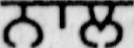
ਨਾਲ
